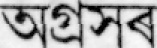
অগ্ৰসৰ
